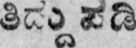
ತಿದ್ದುಪಡಿ
